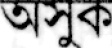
অসুক
